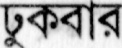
ঢুকবার
